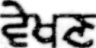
ਵੇਖਣ
